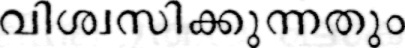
വിശ്വസിക്കുന്നതും
